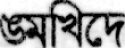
ঙমখিদে
